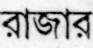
রাজার
